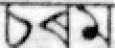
চৰম
